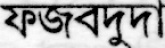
ফজবদুদা
